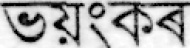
ভয়ংকৰ
